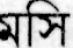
মসি
